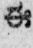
ಈ
